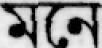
মনে
